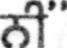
ਨੀ''
